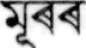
মূৰৰ
